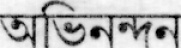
অভিনন্দন
